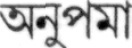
অনুপমা
